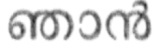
ഞാന്‍
